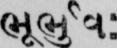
ભૂર્ભુવઃ
